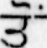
ਤੋਂ
